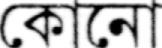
কোনো
